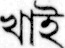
খাই
